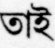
তাই
